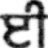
ਈ
